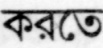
করতে
